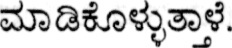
ಮಾಡಿಕೊಳ್ಳುತ್ತಾಳೆ.
